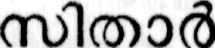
സിതാര്‍
